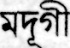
মদূগী
